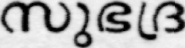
സുഭദ്ര
